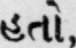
હતો,
